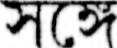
সঙ্গে
